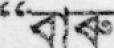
"বাৰু
